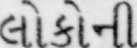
લોકોની
